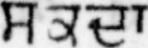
ਸਕਦਾ
